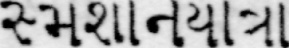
સ્મસાનયાત્રા
